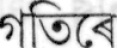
গতিৰে
